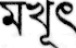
মখূৎ
